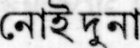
নোইদুনা
